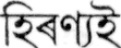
হিৰণ্যই
